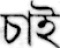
চাই
